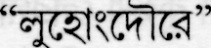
“লুহোংদৌরে”
